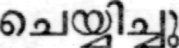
ചെയ്യിച്ചു
